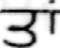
ਤਾਂ
